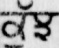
ਕੁੱਝ
